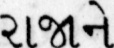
રાજાને
